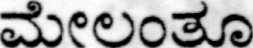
ಮೇಲಂತೂ
